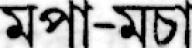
মপা-মচা
